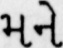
મને
